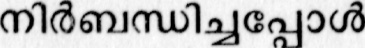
നിര്‍ബന്ധിച്ചപ്പോള്‍
